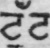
ਟੁੱਟ
